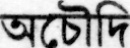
অচৌদি
